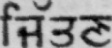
ਜਿੱਤਣ
